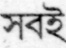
সবই
